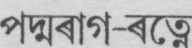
পদ্মৰাগ-ৰত্নে
